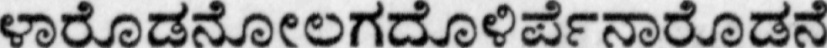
ಳಾರೊಡನೋಲಗದೊಳಿರ್ಪೆನಾರೊಡನೆ
